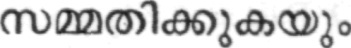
സമ്മതിക്കുകയും
